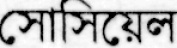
সোসিয়েল
